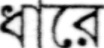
ধারে
